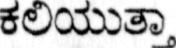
ಕಲಿಯುತ್ತಾ
